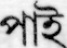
পাই
